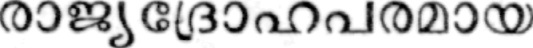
രാജ്യദ്രോഹപരമായ
